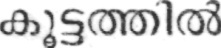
കൂട്ടത്തില്‍
